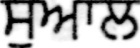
ਸੁਆਲ
